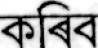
কৰিব
